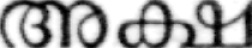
അക്ഷ
